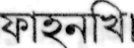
ফাহনখি।
